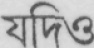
যদিও
